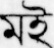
মই
